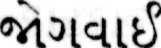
જોગવાઈ
